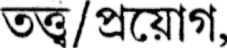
তত্ত্ব/প্রয়োগ,
